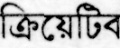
ক্রিয়েটিব
